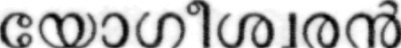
യോഗീശ്വരന്‍
